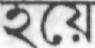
হয়ে
